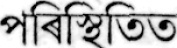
পৰিস্থিতিত
